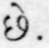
છે.
